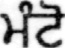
ਮੰਟੋ
